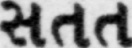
સતત
